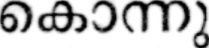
കൊന്നു
